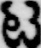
ಟ
